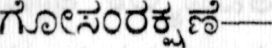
ಗೋಸಂರಕ್ಷಣೆ-
